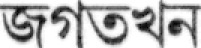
জগতখন
